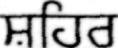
ਸ਼ਹਿਰ
